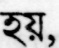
হয়,
